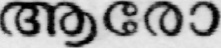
ആരോ
